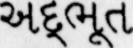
અદ્ભૂત
